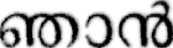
ഞാന്‍
